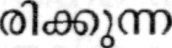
രിക്കുന്ന
